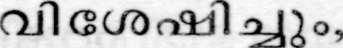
വിശേഷിച്ചും,
